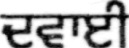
ਦਵਾਈ
